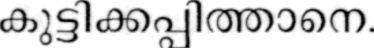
കുട്ടിക്കപ്പിത്താനെ.
